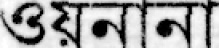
ওয়নানা
